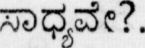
ಸಾಧ್ಯವೇ?.
